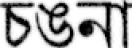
চঙনা
